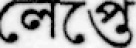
লেপ্তে
